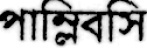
পাম্লিবসি
